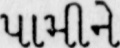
પામીને
